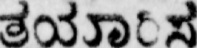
ತಯಾರಿಸ
